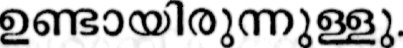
ഉണ്ടായിരുന്നുള്ളു.
